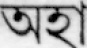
অহা
